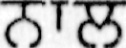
ਨਾਲ
